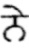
ਨੇ
